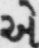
એ
